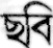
ছবি
